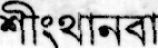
শীংথানবা
